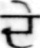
ਦੇ
